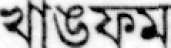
খাঙফম
